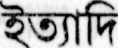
ইত্যাদি
